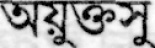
অয়ুক্তসু
